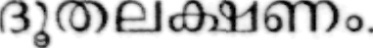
ദൂതലക്ഷണം.
